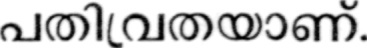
പതിവ്രതയാണ്.
